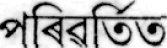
পৰিৱর্তিত
